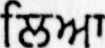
ਲਿਆ
